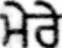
ਮੇਰੇ
